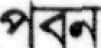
পবন
